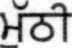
ਮੁੱਠੀ
